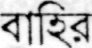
বাহির
